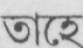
তাহে
